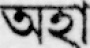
অহা
